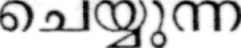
ചെയ്യുന്ന
